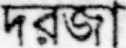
দরজা
